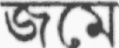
জমে
